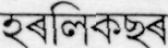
হৰলিকছৰ
